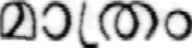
മാത്രം
